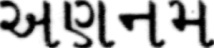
અણનમ
